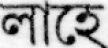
লাহে
